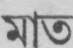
মাত
